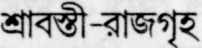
শ্রাবস্তী-রাজগৃহ
